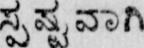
ಸ್ಪಷ್ಟವಾಗಿ
